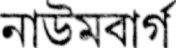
নাউমবার্গ
